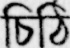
চিঠি
